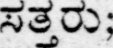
ಸತ್ತರು;
